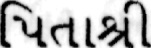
પિતાશ્રી
